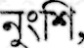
নুংশি,
